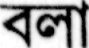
বলা
